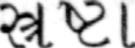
સ્ત્રષ્ટા
